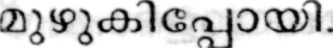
മുഴുകിപ്പോയി.
